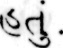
હતું.
